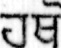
ਹਥੋ
